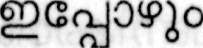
ഇപ്പോഴും
